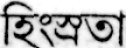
হিংস্রতা
